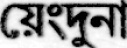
য়েংদুনা
